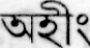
অহীং
